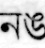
নঙ
